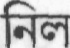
নিল
